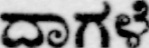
ದಾಗಳೆ
